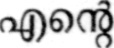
എന്റെ
